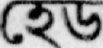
হেড
